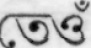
তেওঁ
